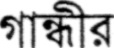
গান্ধীর
